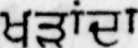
ਖੜਾਂਦਾ
